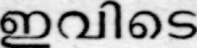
ഇവിടെ
